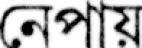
নেপায়
